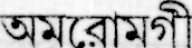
অমরোমগী
